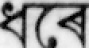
ধৰে
